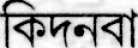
কিদনবা
